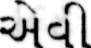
એવી
